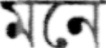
মনে
